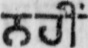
ਨਹੀਂ
